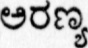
ಅರಣ್ಯ
